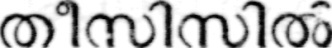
തീസിസില്‍
